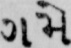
ગમે
